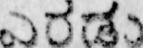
ಎರಡು
